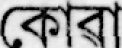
কোৱা
